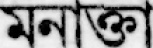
মনাক্তা
